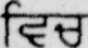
ਵਿਚ
